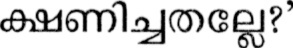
ക്ഷണിച്ചതല്ലേ?’
